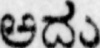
ಅದು
